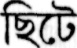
ছিটে
